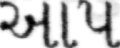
આપ
